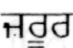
ਜ਼ਰੂਰ
